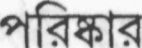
পরিষ্কার
